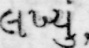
લખ્યું,
